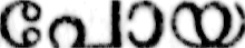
പോയ
